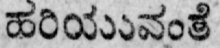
ಹರಿಯುವಂತೆ
